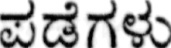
ಪಡೆಗಳು
